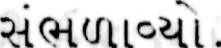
સંભળાવ્યો.
